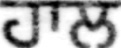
ਹਾਲ
